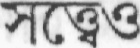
সত্ত্বেও
